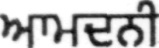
ਆਮਦਨੀ
